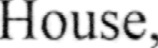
House,
